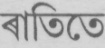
ৰাতিতে
